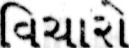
વિચારો
